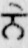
ਨੇ
